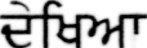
ਦੇਖਿਆ
